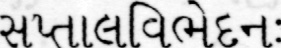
સપ્તાલવિભેદનઃ
